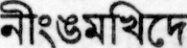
নীংঙমখিদে
